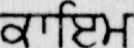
ਕਾਇਮ
